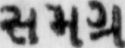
સમગ્ર
